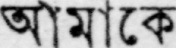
আমাকে
